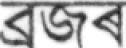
ব্ৰজৰ
